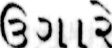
ઉગારે
